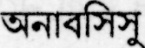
অনাবসিসু
